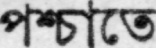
পশ্চাতে
